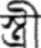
স্ত্রী
